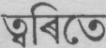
ত্বৰিতে
